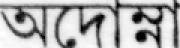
অদোম্না
